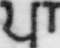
ਪਾ
